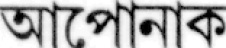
আপোনাক
